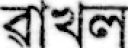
ৱাখল
